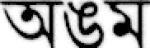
অঙম
